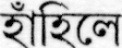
হাঁহিলে
